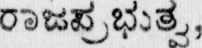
ರಾಜಪ್ರಭುತ್ವ,
